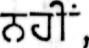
ਨਹੀਂ,
